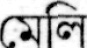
মেলি
